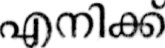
എനിക്ക്
